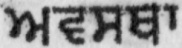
ਅਵਸਥਾ
